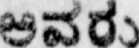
ಅವರು
